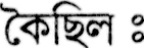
কৈছিলঃ
